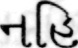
નહિ
